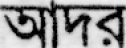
আদর
